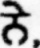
ਨੇ,
